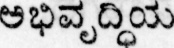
ಅಭಿವೃದ್ಧಿಯ
